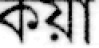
কয়া
